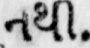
નથી.
